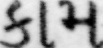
કામ
